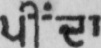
ਪੀਂਦਾ
